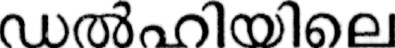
ഡല്‍ഹിയിലെ
